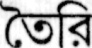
তৈরি
